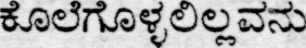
ಕೊಲೆಗೊಳ್ಳಲಿಲ್ಲವನು
